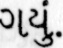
ગયું.
